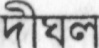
দীঘল
